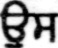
ਉਸ
